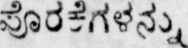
ಪೊರಕೆಗಳನ್ನು
